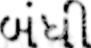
બંધી
